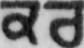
ਕਰ
